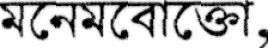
মনেমবোক্তো,
